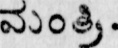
ಮಂತ್ರಿ.
